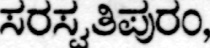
ಸರಸ್ವತಿಪುರಂ,
